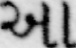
આ
